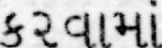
કરવામાં
